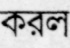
করল
